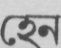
হেন
